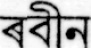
ৰবীন
